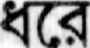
ধরে
